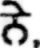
ਨੇ,
